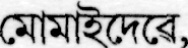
মোমাইদেৱে,
